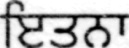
ਇਤਨਾ
